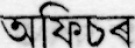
অফিচৰ
